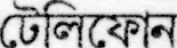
টেলিফোন
